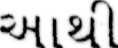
આથી
